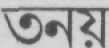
তনয়
